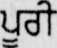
ਪੂਰੀ
